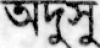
অদুসু
